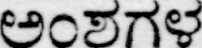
ಅಂಶಗಳ
